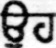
ਉਹ
